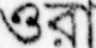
ওরা
